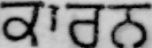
ਕਾਰਨ
